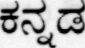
ಕನ್ನಡ
